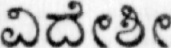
ವಿದೇಶೀ
